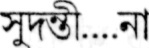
সুদন্তী....না
